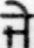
ਜੇ
